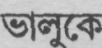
ভালুকে
